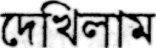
দেখিলাম
